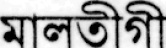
মালতীগী
